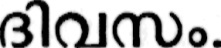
ദിവസം.
